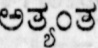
ಅತ್ಯಂತ
